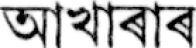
আখাৰাৰ
